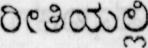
ರೀತಿಯಲ್ಲಿ
